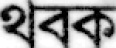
থবক
